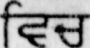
ਵਿਚ
